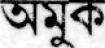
অমুক
